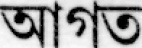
আগত
